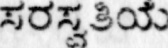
ಸರಸ್ವತಿಯೆ
